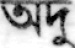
অদু
